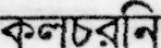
কলচরনি
